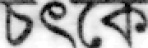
চৎকে
